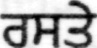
ਰਸਤੇ
